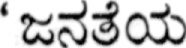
'ಜನತೆಯ
